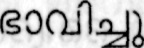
ഭാവിച്ചു
